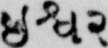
ઈશ્વર
